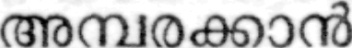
അമ്പരക്കാന്‍
